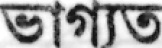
ভাগ্যত
